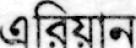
এরিয়ান
